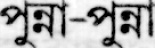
পুন্না-পুন্না
